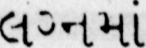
લગ્નમાં
